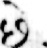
છે.
